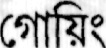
গোয়িং
